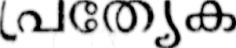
പ്രത്യേക
